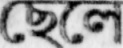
ছেলে
